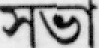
সভা
